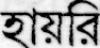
হায়রি
